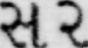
સર
